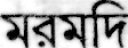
মরমদি
